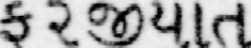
ફરજીયાત
